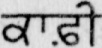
ਕਾਫ਼ੀ
